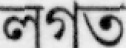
লগত
